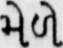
મેળે
